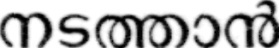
നടത്താന്‍
